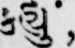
કહ્યું,
